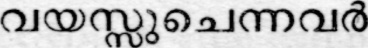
വയസ്സുചെന്നവര്‍
